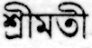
শ্রীমতী
